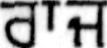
ਰਾਜ
